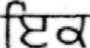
ਇਕ
